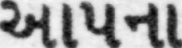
આપના
